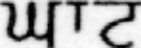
ਘਾਟ
